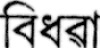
বিধৱা
